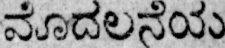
ಮೊದಲನೆಯ
